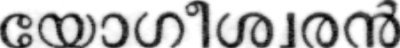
യോഗീശ്വരന്‍
